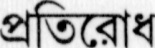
প্রতিরোধ
